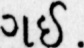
ગઈ.
